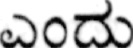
ಎಂದು
